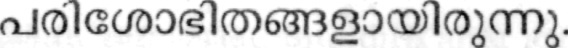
പരിശോഭിതങ്ങളായിരുന്നു.
